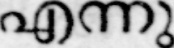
എന്നു
